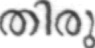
തിരു
